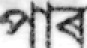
পাৰ
